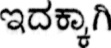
ಇದಕ್ಕಾಗಿ
